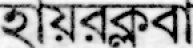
হায়রক্লবা
